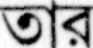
তার
